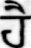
ਹੈ
